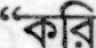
“করি
